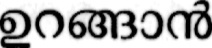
ഉറങ്ങാന്‍
